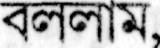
বললাম,
